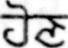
ਹੋਣ
